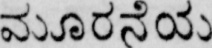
ಮೂರನೆಯ
